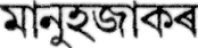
মানুহজাকৰ
